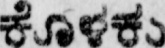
ಕೊಳಕು
